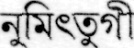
নুমিৎতুগী
